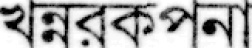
খন্নরকপনা
